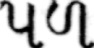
પળ
